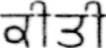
ਕੀਤੀ
